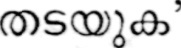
തടയുക'
